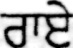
ਰਾਏ
